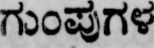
ಗುಂಪುಗಳ
